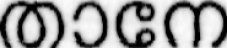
താനേ
